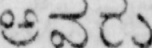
ಅವರು
